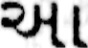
આ
